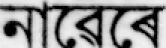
নাৱেৰে
